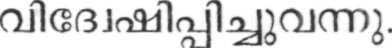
വിദ്വേഷിപ്പിച്ചുവന്നു.
